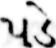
પડે
